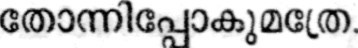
തോന്നിപ്പോകുമത്രേ.
